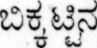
ಬಿಕ್ಕಟ್ಟಿನ
